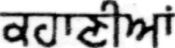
ਕਹਾਣੀਆਂ
